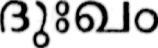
ദുഃഖം
